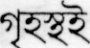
গৃহস্থই
